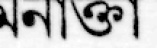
মনাক্তা
